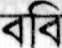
ববি
